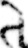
તે
